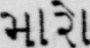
મારો
